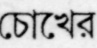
চোখের
